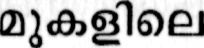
മുകളിലെ
